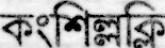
কংশিল্লক্লি
